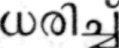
ധരിച്ച്
